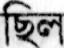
ছিল
